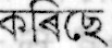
কৰিছে
